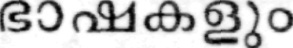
ഭാഷകളും
